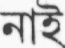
নাই
